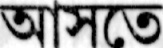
আসতে
